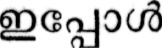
ഇപ്പോള്‍
